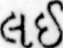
લઈ
